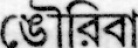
ঙৌরিবা
